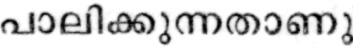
പാലിക്കുന്നതാണു
